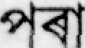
পৰা
